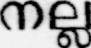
നല്ല
